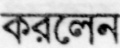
করলেন
